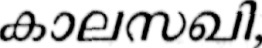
കാലസഖി,
